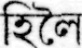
হিলৈ
